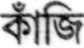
কাঁজি
